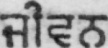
ਜੀਵਨ
